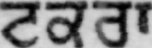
ਟਕਰਾ
